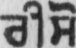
ਰੀਸੋ
